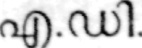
എ.ഡി.
